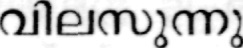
വിലസുന്നു
